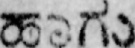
ಹಾಗು
